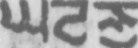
ਘਟਣ
